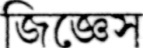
জিজ্ঞেস
